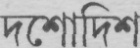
দশোদিশ
